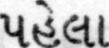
પહેલા
